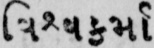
વિશ્વકર્મા
